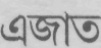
এজাত
